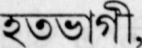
হতভাগী,
